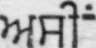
ਅਸੀਂ
